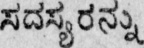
ಸದಸ್ಯರನ್ನು
